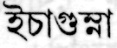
ইচাগুম্না
